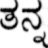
ತನ್ನ
